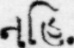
નહિ.
